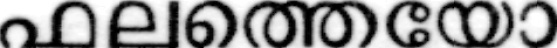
ഫലത്തെയോ
